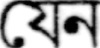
যেন
